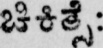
ಚಿಕಿತ್ಸೆ:
